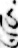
હું
